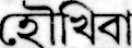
হৌখিবা
